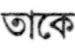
তাকে
